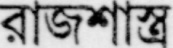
রাজশাস্ত্র
